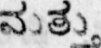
ಮತ್ತು
